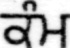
ਕੰਮ
